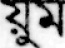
য়ুম
